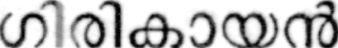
ഗിരികായന്‍
